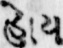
હોય
